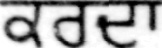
ਕਰਦਾ
